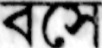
বসে
